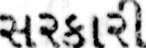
સરકારી
